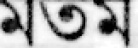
মতম
